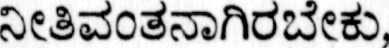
ನೀತಿವಂತನಾಗಿರಬೇಕು,
